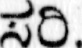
ಸರಿ.
